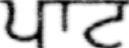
ਪਾਟ
